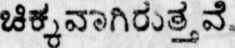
ಚಿಕ್ಕವಾಗಿರುತ್ತವೆ.
